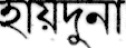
হায়দুনা
